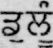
ਡੁਲੂੰ
